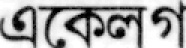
একেলগ
